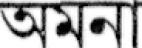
অমনা
